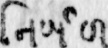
નિર્બળ
